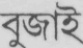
বুজাই
